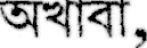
অখাবা,
